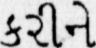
કરીને
